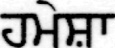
ਹਮੇਸ਼ਾ
